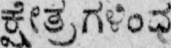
ಕ್ಷೇತ್ರಗಳಿಂದ
